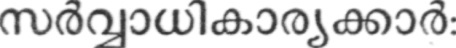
സര്‍വ്വാധികാര്യക്കാര്‍:
